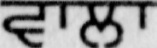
ਵਾਲਾ
